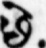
છે.
